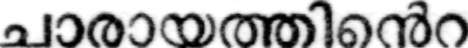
ചാരായത്തിന്റെ
